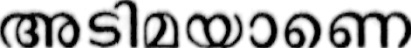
അടിമയാണെ
